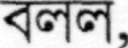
বলল,
